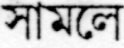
সামলে
